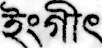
ইংগীৎ
